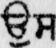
ਉਸ
